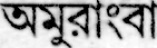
অমুরাংবা
